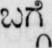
ಬಗ್ಗೆ
